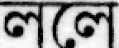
ললে
